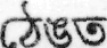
ঠেঙত
